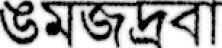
ঙমজদ্রবা
